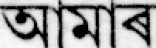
আমাৰ
